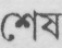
শেষ
